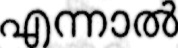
എന്നാല്‍
